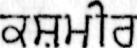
ਕਸ਼ਮੀਰ
